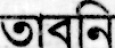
তাবনি
